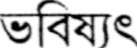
ভবিষ্যৎ
